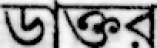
ডাক্তর
